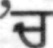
'ਚ
